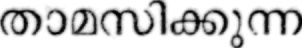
താമസിക്കുന്ന
